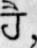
ਹੈ,
